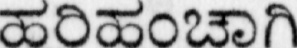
ಹರಿಹಂಚಾಗಿ
